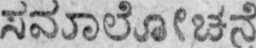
ಸಮಾಲೋಚನೆ
